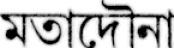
মতাদৌনা
